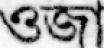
ওজা
